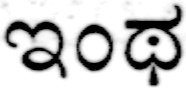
ಇಂಥ
